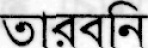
তারবনি
